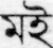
মই
